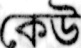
কেউ
